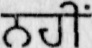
ਨਹੀਂ
